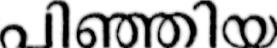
പിഞ്ഞിയ
